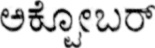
ಅಕ್ಟೋಬರ್
